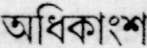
অধিকাংশ
